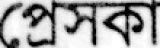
প্রেসকা
